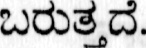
ಬರುತ್ತದೆ.
